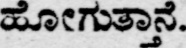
ಹೋಗುತ್ತಾನೆ.
